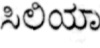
ಸಿಲಿಯಾ
